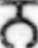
ਨ
